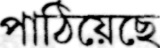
পাঠিয়েছে
